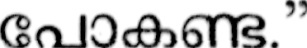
പോകണ്ട."
